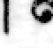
ৱা
